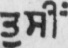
ਤੁਸੀਂ
